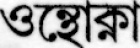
ওন্থোক্না
